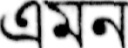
এমন
